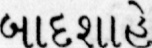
બાદશાહે
